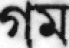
গম
